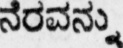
ನೆರವನ್ನು
